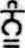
ਨੂੰ
